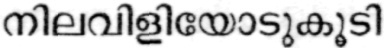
നിലവിളിയോടുകൂടി
